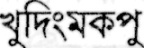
খুদিংমকপু
